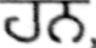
ਹਨ,
